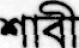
শাবী
